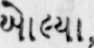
બોલ્યા,
